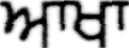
ਆਖਾ
